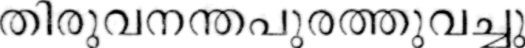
തിരുവനന്തപുരത്തുവച്ചു
